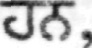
ਹਨ,
